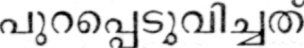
പുറപ്പെടുവിച്ചത്
